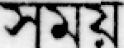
সময়
